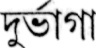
দুর্ভাগা
